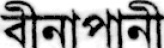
বীনাপানী
